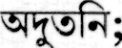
অদুতনি;
